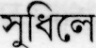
সুধিলে
